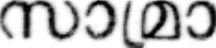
സാമ്രാ
